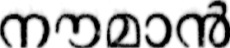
നൌമാന്‍
